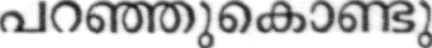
പറഞ്ഞുകൊണ്ടു
